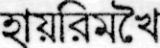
হায়রিমখৈ
